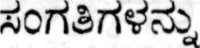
ಸಂಗತಿಗಳನ್ನು
